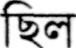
ছিল
